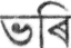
ভৰি
